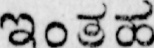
ಇಂತಹ
